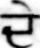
ਦੇ
